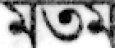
মতম
